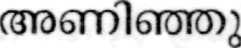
അണിഞ്ഞു
